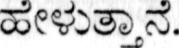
ಹೇಳುತ್ತಾನೆ.
